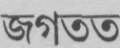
জগতত
